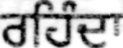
ਰਹਿੰਦਾ
